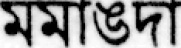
মমাঙদা
